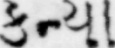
કન્યા
